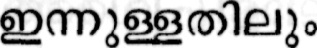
ഇന്നുള്ളതിലും
